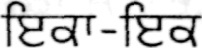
ਇਕਾ-ਇਕ
